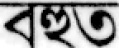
বহুত
